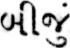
બીજું
